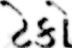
ટેકો
